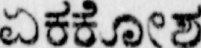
ಏಕಕೋಶ
